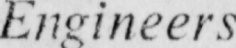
Engineers
